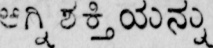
ಅಗ್ನಿಶಕ್ತಿಯನ್ನು
